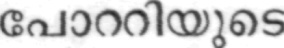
പോററിയുടെ
